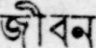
জীবন
